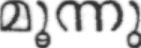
മൂന്നു
